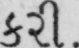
કરી.
